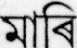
মাৰি
